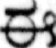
ಈ
